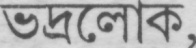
ভদ্রলোক,
